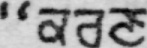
''ਕਰਣ
